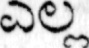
ಎಲ್ಲ
